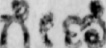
ಗೇಣಿ
